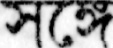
সঙ্গে
